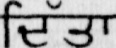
ਦਿੱਤਾ
